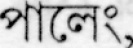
পালেং,
